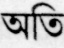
অতি
